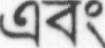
এবং
